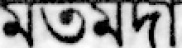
মতমদা
